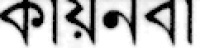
কায়নবা
